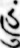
હું
